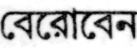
বেরোবেন
